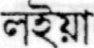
লইয়া
